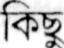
কিছু
